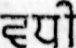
ਵਧੀ
